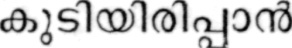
കുടിയിരിപ്പാന്‍
